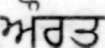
ਔਰਤ
